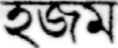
হজম
